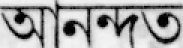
আনন্দত
